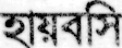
হায়বসি
